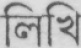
লিখি
